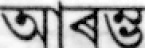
আৰম্ভ
